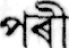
পৰী
